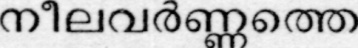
നീലവര്‍ണ്ണത്തെ
